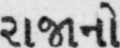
રાજાનો
